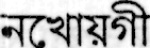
নখোয়গী
